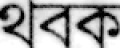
থবক
